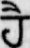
ਹੈ
